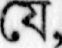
যে,
